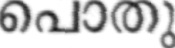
പൊതു
